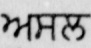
ਅਸਲ
